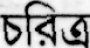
চরিত্র
